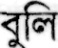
বুলি
